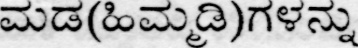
ಮಡ(ಹಿಮ್ಮಡಿ)ಗಳನ್ನು
